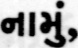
નામું,
